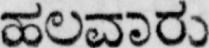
ಹಲವಾರು
